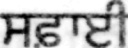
ਸਫ਼ਾਈ
